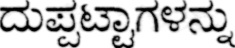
ದುಪ್ಪಟ್ಟಾಗಳನ್ನು
